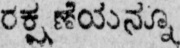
ರಕ್ಷಣೆಯನ್ನೂ
